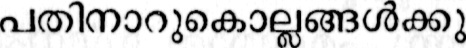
പതിനാറുകൊല്ലങ്ങള്‍ക്കു
